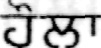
ਹੌਲਾ
